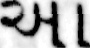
આ
